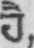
ਹੈ,
